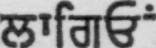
ਲਾਗਿਓਂ
